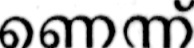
ണെന്ന്
